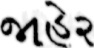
જાહેર
